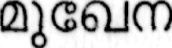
മുഖേന
